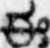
ಈ
